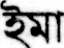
ইমা
